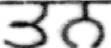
ਤਨ
